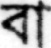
বা
